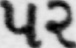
પર
